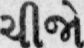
ચીજો
